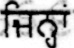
ਜਿਨ੍ਹਾਂ
